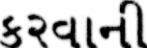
કરવાની
